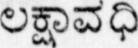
ಲಕ್ಷಾವಧಿ
